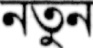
নতুন
